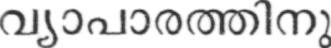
വ്യാപാരത്തിനു
